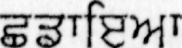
ਛਡਾਇਆ
